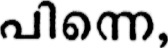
പിന്നെ,
